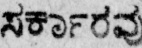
ಸರ್ಕಾರವು
